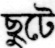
ছুটে
